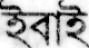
ইবাই
